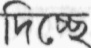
দিচ্ছে
